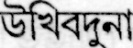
উখিবদুনা
